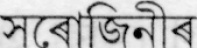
সৰোজিনীৰ
